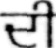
ਦੀ
